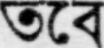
তবে
